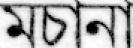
মচানা
